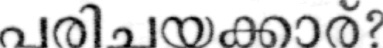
പരിചയക്കാര്?
